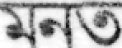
মনত
